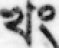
খং
